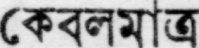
কেবলমাত্র
